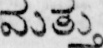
ಮತ್ತು
